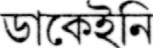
ডাকেইনি
